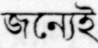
জন্যেই
